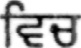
ਵਿਚ
